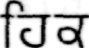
ਹਿਕ
